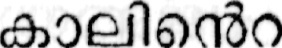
കാലിന്റെ
